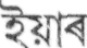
ইয়াৰ
